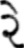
રે
